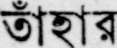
তাঁহার
